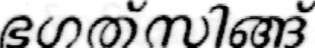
ഭഗത്സിങ്ങ്
